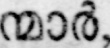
ന്മാര്‍,
